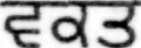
ਵਕਤ
